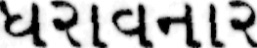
ધરાવનાર
